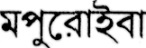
মপুরোইবা
